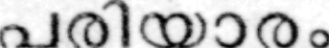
പരിയാരം
